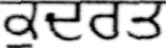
ਕੁਦਰਤ
